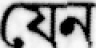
যেন
